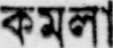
কমলা
